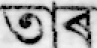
তাৰ
